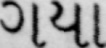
ગયા
